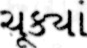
ચૂક્યાં
